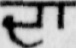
ਦਾ
